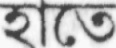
হাতে
